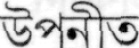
উপনীত
